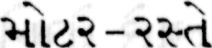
મોટર-રસ્તે
